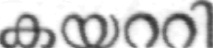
കയററി
